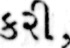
કરી,
